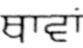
ਥਾਵਾਂ
